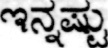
ಇನ್ನಷ್ಟು
